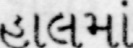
હાલમાં
